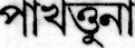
পাখত্তুনা
